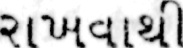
રાખવાથી
